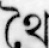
থৈ
